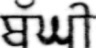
ਬੱਘੀ
